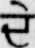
ਦੇ
